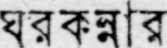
ঘরকন্নার
